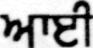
ਆਈ
